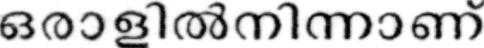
ഒരാളില്‍നിന്നാണ്
